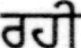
ਰਹੀ
